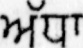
ਅੱਧਾ
